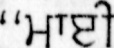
''ਮਾਈ
